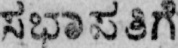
ಸಭಾಪತಿಗೆ
